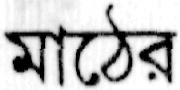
মাঠের
